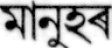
মানুহৰ
